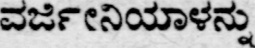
ವರ್ಜೀನಿಯಾಳನ್ನು
